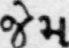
જેમ
